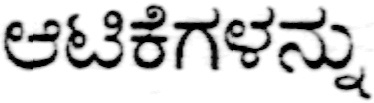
ಆಟಿಕೆಗಳನ್ನು
